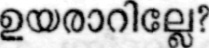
ഉയരാറില്ലേ?
